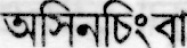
অসিনচিংবা
